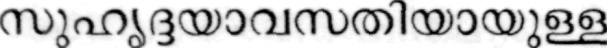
സുഹൃദ്ദയാവസതിയായുള്ള
